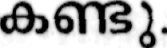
കണ്ടു.
